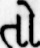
તો
